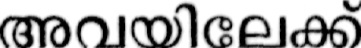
അവയിലേക്ക്
